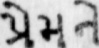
પ્રેમને
